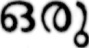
ഒരു
